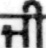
ਜੀ
